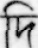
দি
